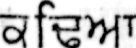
ਕਢਿਆ
